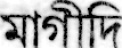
মাগীদি
